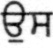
ਉਸ
